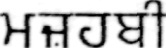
ਮਜ਼ਹਬੀ
